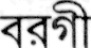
বরগী
